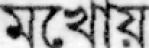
মখোয়
